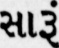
સારૂં
